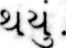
થયું.
